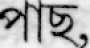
পাছ,
